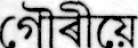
গৌৰীয়ে
